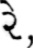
રે,
